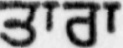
ਤਾਰਾ
